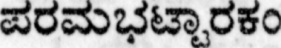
ಪರಮಭಟ್ಟಾರಕಂ
